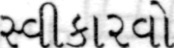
સ્વીકારવો
